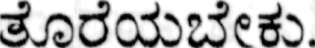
ತೊರೆಯಬೇಕು.
